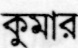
কুমার
